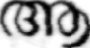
ആ
